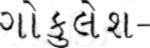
ગોકુલેશ-
